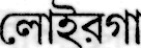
লোইরগা
